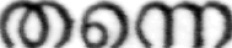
തന്നെ
